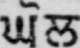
ਘੋਲ
